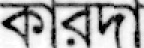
কারদা
